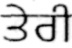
ਤੇਰੀ
